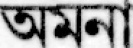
অমনা
